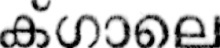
ക്ഗാലെ
